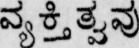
ವ್ಯಕ್ತಿತ್ವವು
